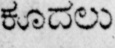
ಕೂದಲು
